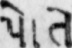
પોતે
